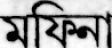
মফিনা
